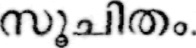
സൂചിതം.
